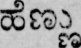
ಹೆಣ್ಣು
